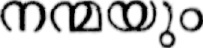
നന്മയും
